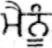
ਮੈਨੂੰ
